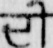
ਦੀ
